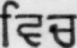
ਵਿਚ
